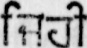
ਜਿਹੀ
